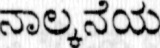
ನಾಲ್ಕನೆಯ
